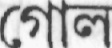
গোল
